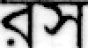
রস
